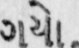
ગયો.
